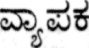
ವ್ಯಾಪಕ
